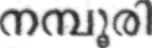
നമ്പൂരി
